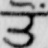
ਤੋਂ
